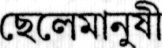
ছেলেমানুষী
